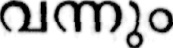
വന്നും
